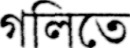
গলিতে
